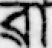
ৱা
